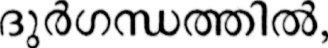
ദുര്‍ഗന്ധത്തില്‍,
